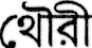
থৌরী
